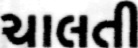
ચાલતી
